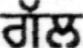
ਗੱਲ
